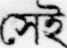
সেই
